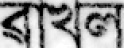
ৱাখল
